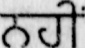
ਨਹੀਂ
